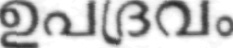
ഉപദ്രവം
